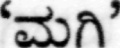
‘ಮಗಿ’
